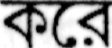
করে
